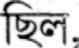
ছিল,
